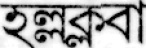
হল্লক্লবা
